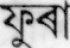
ফুৰা
